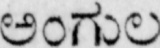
ಅಂಗುಲ
